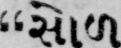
“સોળ
